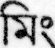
মিং
